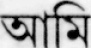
আমি
